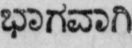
ಭಾಗವಾಗಿ
